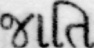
જાતિ
